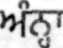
ਅੰਨ੍ਹਾ
